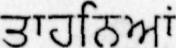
ਤਾਹਨਿਆਂ
